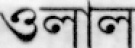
ওলাল
